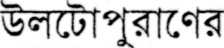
উলটোপুরাণের
